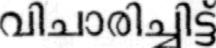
വിചാരിച്ചിട്ട്
